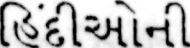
હિંદીઓની
